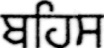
ਬਹਿਸ
